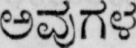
ಅವುಗಳ
